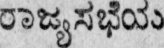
ರಾಜ್ಯಸಭೆಯ
